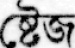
ষ্টেজ
